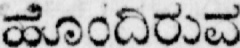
ಹೊಂದಿರುವ
